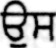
ਉਸ
